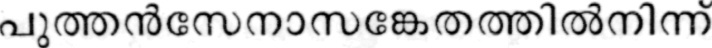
പുത്തന്‍സേനാസങ്കേതത്തില്‍നിന്ന്
